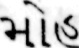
મોહ
